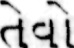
તેવો
